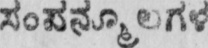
ಸಂಪನ್ಮೂಲಗಳ
